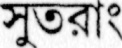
সুতরাং
